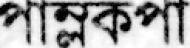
পুম্লকপা
